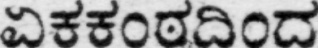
ಏಕಕಂಠದಿಂದ
